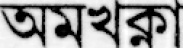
অমখক্না
